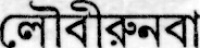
লৌবীরুনবা
